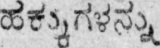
ಹಕ್ಕುಗಳನ್ನು
